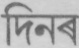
দিনৰ
